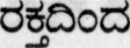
ರಕ್ತದಿಂದ
